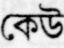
কেউ
